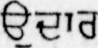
ਉਦਾਰ
